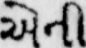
એની
